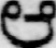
ಆ
